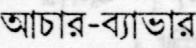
আচার-ব্যাভার
